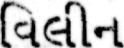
વિલીન
